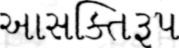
આસક્તિરૂપ
